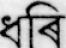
ধৰি
